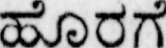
ಹೊರಗೆ
